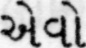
એવો
